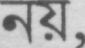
নয়,
